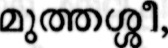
മുത്തശ്ശീ,
